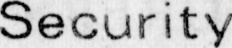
Security
